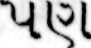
પણ
